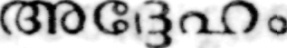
അദ്ദേഹം
